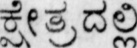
ಕ್ಷೇತ್ರದಲ್ಲಿ
